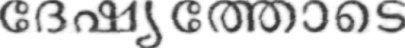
ദേഷ്യത്തോടെ
